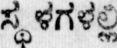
ಸ್ಥಳಗಳಲ್ಲಿ
